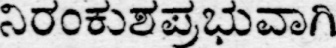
ನಿರಂಕುಶಪ್ರಭುವಾಗಿ
